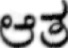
ಆತ
